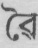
ৱৈ
